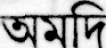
অমদি
